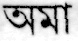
অমা
